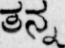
ತನ್ನ
